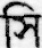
সি
